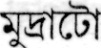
মুদ্ৰাটো
